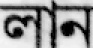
লান
